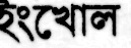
ইংখোল
